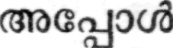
അപ്പോള്‍
